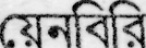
য়েনবিরি
